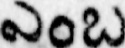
ಎಂಬ
